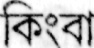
কিংবা
